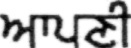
ਆਪਣੀ
